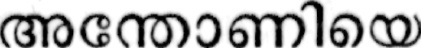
അന്തോണിയെ
